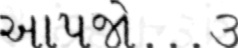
આપજો...૩
